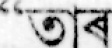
"তাৰ
